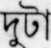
দুটা
